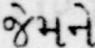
જેમને
